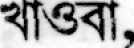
খাওবা,
